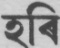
হৰি
